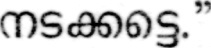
നടക്കട്ടെ.”
